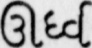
ઊર્ધ્વ
